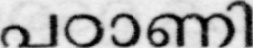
പഠാണി
